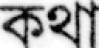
কথা
